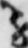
કે
